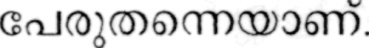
പേരുതന്നെയാണ്.
